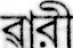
ৱারী
